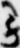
કે
